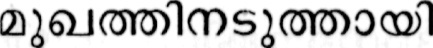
മുഖത്തിനടുത്തായി
